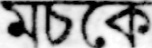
মচকে
